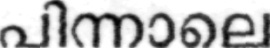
പിന്നാലെ
